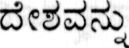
ದೇಶವನ್ನು
